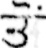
ਤੋਂ
